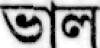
ভাল
